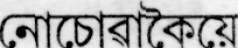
নোচোৱাকৈয়ে
